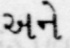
અને
